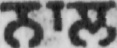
ਨਾਲ
